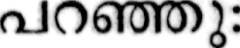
പറഞ്ഞു:
